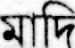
মাদি
